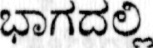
ಭಾಗದಲ್ಲಿ
